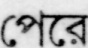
পেরে
